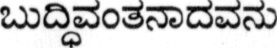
ಬುದ್ಧಿವಂತನಾದವನು
